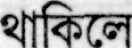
থাকিলে
